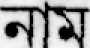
নাম
